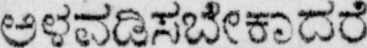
ಅಳವಡಿಸಬೇಕಾದರೆ
